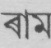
ৰাম
